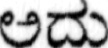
ಅದು
